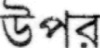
উপর
